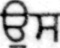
ਉਸ
